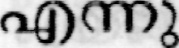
എന്നു
